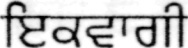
ਇਕਵਾਗੀ
